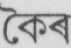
কৈৰ
